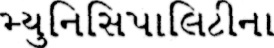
મ્યુનિસિપાલિટીના
